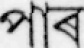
পাৰ
